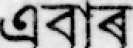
এবাৰ
